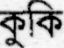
কুকি
